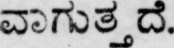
ವಾಗುತ್ತದೆ.
